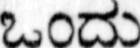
ಒಂದು
